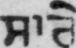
ਸਾਰੇ
